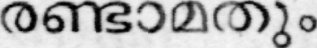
രണ്ടാമതും
